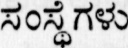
ಸಂಸ್ಥೆಗಳು
